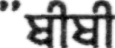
''ਬੀਬੀ
